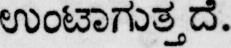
ಉಂಟಾಗುತ್ತದೆ.
